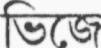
ভিজে
